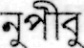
নুপীবু
